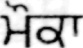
ਮੌਕਾ
